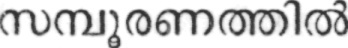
സമ്പൂരണത്തില്‍
